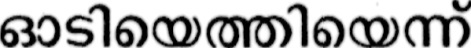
ഓടിയെത്തിയെന്ന്
